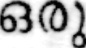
ഒരു
